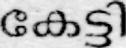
കേട്ടി
